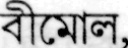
বীমোল,
